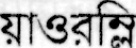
য়াওরম্লি
